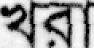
খরা
